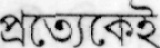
প্রত্যেকেই
